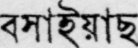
বসাইয়াছ
